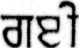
ਗਈ
